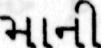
માની
